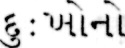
દુઃખોનો
